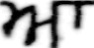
ਆ
